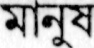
মানুষ
